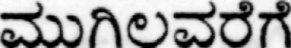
ಮುಗಿಲವರೆಗೆ
